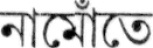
নামোঁতে
